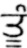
ਤੂੰ
